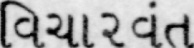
વિચારવંત
